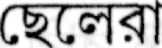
ছেলেরা
